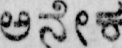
ಅನೇಕ
